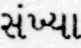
સંખ્યા
